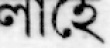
লাহে
